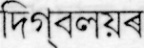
দিগ্‌বলয়ৰ
